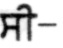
ਸੀ-
